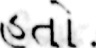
હતો.
